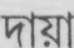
দায়া
